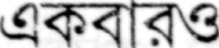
একবারও
